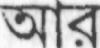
আর
